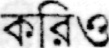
করিও
